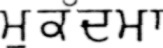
ਮੁਕੱਦਮਾ
